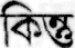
কিন্তু
